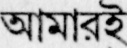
আমারই
